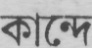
কান্দে
